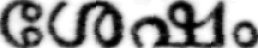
ശേഷം
